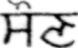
ਸੌਣ
